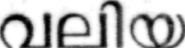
വലിയ
